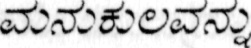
ಮನುಕುಲವನ್ನು
